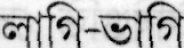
লাগি-ভাগি
